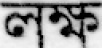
লক্ষ
